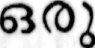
ഒരു
